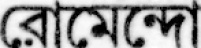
রোমেন্দো
